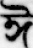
ঈ
